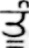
ਤੂੰ
